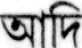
আদি
